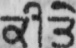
ਕੀਤੇ
